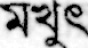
মখুৎ
